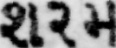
શરમ
